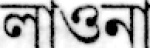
লাওনা
